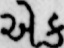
એક
